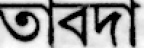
তাবদা
